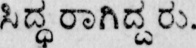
ಸಿದ್ಧರಾಗಿದ್ದರು.
